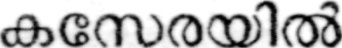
കസേരയില്‍
